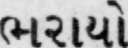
ભરાયો
